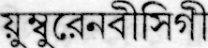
য়ুম্বুরেনবীসিগী
